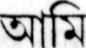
আমি
